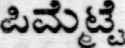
ಪಿಮ್ಮೆಟ್ಟೆ
